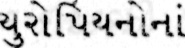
યુરોપિયનોનાં
